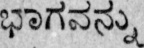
ಭಾಗವನ್ನು
